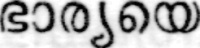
ഭാര്യയെ
